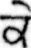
ਕੇ
